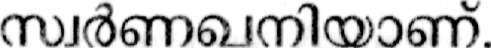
സ്വര്‍ണഖനിയാണ്.
